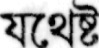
যথেষ্ট
